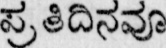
ಪ್ರತಿದಿನವೂ
